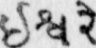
ઇશ્વરે
